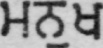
ਮਨੁਖ
